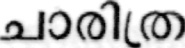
ചാരിത്ര
